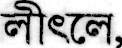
লীৎলে,
